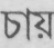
চায়
